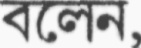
বলেন,
